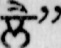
ਲੈ''
